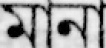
মানা
